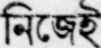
নিজেই
